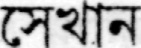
সেখান
